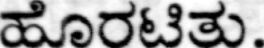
ಹೊರಟಿತು.
